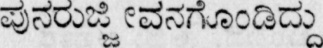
ಪುನರುಜ್ಜೀವನಗೊಂಡಿದ್ದು
